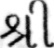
શ્રી
